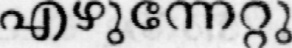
എഴുന്നേറ്റു
